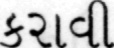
કરાવી
